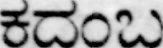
ಕದಂಬ
